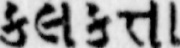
કલકત્તા
